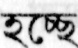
হচ্ছে
